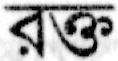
রক্ত
